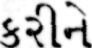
કરીને
